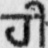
ਹੀ
